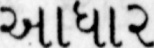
આધાર
